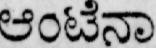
ಆಂಟೆನಾ
